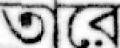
তারে
